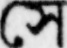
সে
